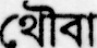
থৌবা
